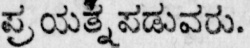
ಪ್ರಯತ್ನಪಡುವರು.
